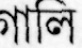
গালি
